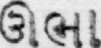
ઊભા
